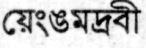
য়েংঙমদ্রবী
